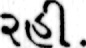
રહી.
